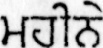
ਮਹੀਨੇ
